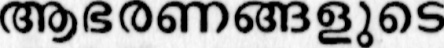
ആഭരണങ്ങളുടെ
